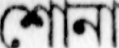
শোনা
